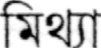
মিথ্যা
